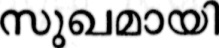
സുഖമായി
